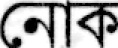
নোক
